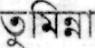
তুমিন্না
